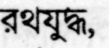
রথযুদ্ধ,
